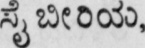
ಸೈಬೀರಿಯ,
